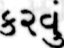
કરવું
